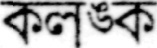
কলঙ্ক
